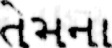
તેમના
